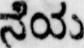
ನೆಯ
